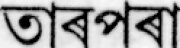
তাৰপৰা
